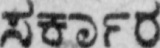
ಸರ್ಕಾರ
